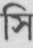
সি
